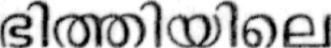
ഭിത്തിയിലെ
